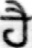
ਹੈ
